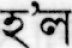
হ'ল
